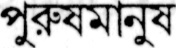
পুরুষমানুষ
